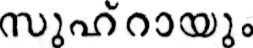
സുഹ്റായും
